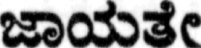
ಜಾಯತೇ
